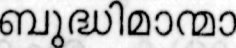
ബുദ്ധിമാന്മാ
